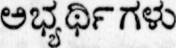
ಅಭ್ಯರ್ಥಿಗಳು
